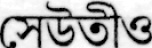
সেউতীও
